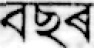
বছৰ
